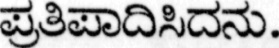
ಪ್ರತಿಪಾದಿಸಿದನು.
